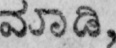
ಮಾಡಿ,
